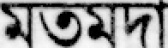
মতমদা
